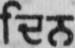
ਦਿਨ
